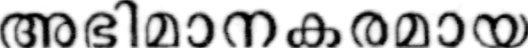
അഭിമാനകരമായ
